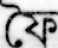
ফৈ
